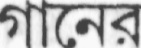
গানের
